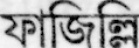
ফাজিল্লি
